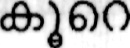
കൂറെ
